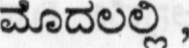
ಮೊದಲಲ್ಲಿ,
